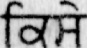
ਕਿਸੇ
